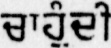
ਚਾਹੁੰਦੀ
